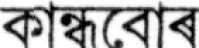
কান্ধবোৰ
